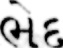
ભેદ
